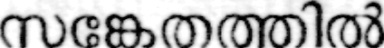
സങ്കേതത്തില്‍
